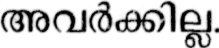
അവര്‍ക്കില്ല.
